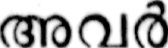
അവര്‍
